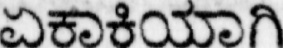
ಏಕಾಕಿಯಾಗಿ
